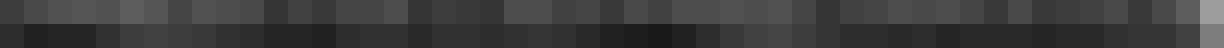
মনুংদা
